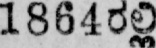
1864ರಲ್ಲಿ
